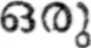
ഒരു
